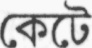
কেটে
